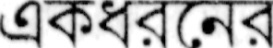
একধরনের
